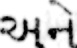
અને
